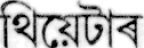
থিয়েটাৰ
